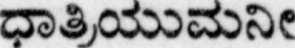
ಧಾತ್ರಿಯುಮನೀ
